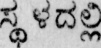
ಸ್ಥಳದಲ್ಲಿ
